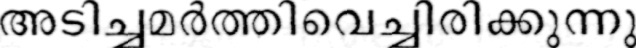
അടിച്ചമര്‍ത്തിവെച്ചിരിക്കുന്നു
